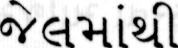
જેલમાંથી
